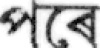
পৰে
